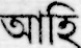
আহি
